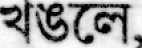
খঙলে,
